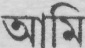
আমি
